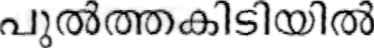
പുല്‍ത്തകിടിയില്‍
